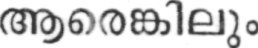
ആരെങ്കിലും
